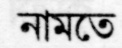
নামতে
